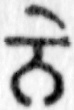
ਨੇ
